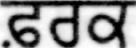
ਫ਼ਰਕ
